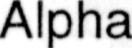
Alpha
